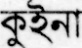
কুইনা
